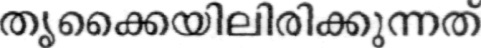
തൃക്കൈയിലിരിക്കുന്നത്
